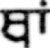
ਥਾਂ
